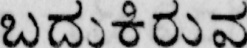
ಬದುಕಿರುವ
